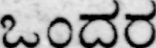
ಒಂದರ
